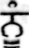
ਨੂੰ
